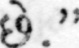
છે.”
